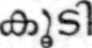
കൂടി
